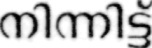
നിന്നിട്ട്
